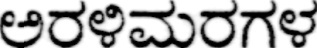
ಅರಳಿಮರಗಳ
